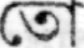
তো
